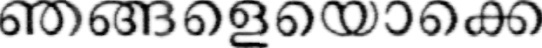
ഞങ്ങളെയൊക്കെ
